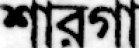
শারগা
